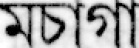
মচাগা
